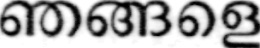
ഞങ്ങളെ
